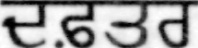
ਦਫ਼ਤਰ
